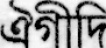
ঐগীদি
